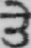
ਤੇ
